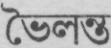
ভৈলন্ত
